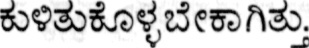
ಕುಳಿತುಕೊಳ್ಳಬೇಕಾಗಿತ್ತು.
